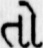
તો
